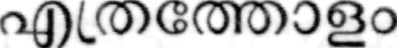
എത്രത്തോളം
